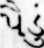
પૈડું
